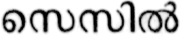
സെസില്‍
